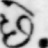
છે.
